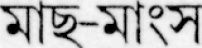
মাছ-মাংস
